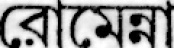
রোমেন্না
